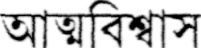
আত্মবিশ্বাস
